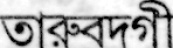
তারুবদগী
